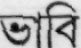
ভাবি
